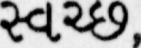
સ્વચ્છ,
